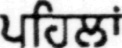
ਪਹਿਲਾਂ
